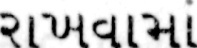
રાખવામાં
